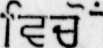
ਵਿਚੋਂ
